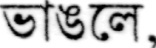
ভাঙলে,
